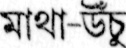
মাথা-উঁচু
